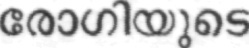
രോഗിയുടെ
